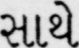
સાથે
